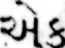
એક
